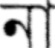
না
